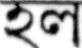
হল
